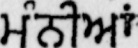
ਮੰਨੀਆਂ
